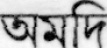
অমদি
